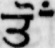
ਤੋਂ
